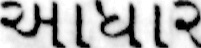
આધાર
